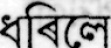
ধৰিলে
